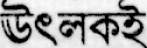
ঊৎলকই
